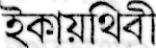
ইকায়থিবী
